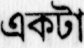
একটা
